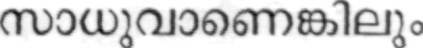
സാധുവാണെങ്കിലും
